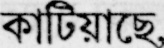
কাটিয়াছে,
